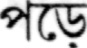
পড়ে
